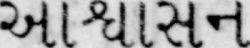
આશ્વાસન
